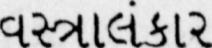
વસ્ત્રાલંકાર
